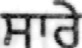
ਸਾਰੇ
